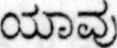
ಯಾವು
